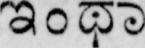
ಇಂಥಾ
